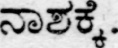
ನಾಶಕ್ಕೆ.
